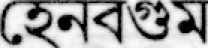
হেনবগুম
